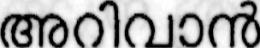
അറിവാന്‍
